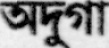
অদুগা
